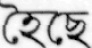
হৈছে
